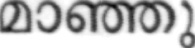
മാഞ്ഞു
